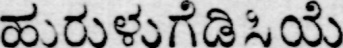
ಹುರುಳುಗೆಡಿಸಿಯೆ
